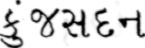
કુંજસદન
